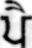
ਪੈ
